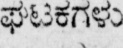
ಘಟಕಗಳು
